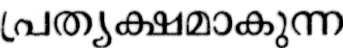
പ്രത്യക്ഷമാകുന്ന
